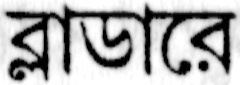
ব্লাডারে
